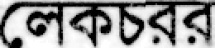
লেকচরর
